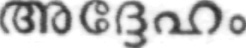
അദ്ദേഹം
